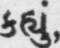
કહ્યું,
